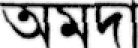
অমদা
